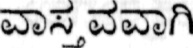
ವಾಸ್ತವವಾಗಿ
